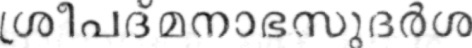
ശ്രീപദ്മനാഭസുദര്‍ശ
